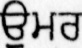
ਉਮਰ
